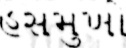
હસમુખો
